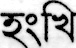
হংখি
